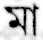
মা
